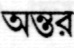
অন্তর
